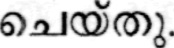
ചെയ്തു.
